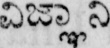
ವಿಜ್ಞಾನಿ
